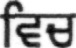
ਵਿਚ
